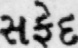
સફેદ
